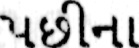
પછીના
